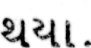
થયા.
